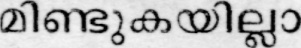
മിണ്ടുകയില്ലാ
